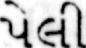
પેલી
